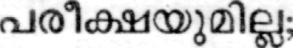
പരീക്ഷയുമില്ല;
